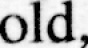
old,
